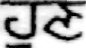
ਹੁਣ
